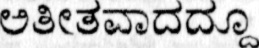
ಅತೀತವಾದದ್ದೂ
